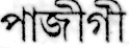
পাজীগী
